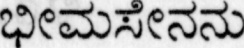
ಭೀಮಸೇನನು
